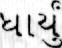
ધાર્યું
